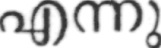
എന്നു
